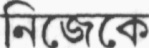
নিজেকে
